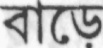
বাড়ে
